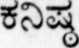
ಕನಿಷ್ಠ
